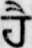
ਹੈ
